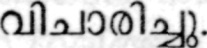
വിചാരിച്ചു.
